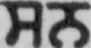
ਸਨ
